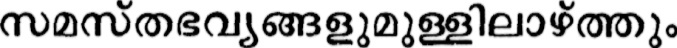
സമസതഭവ്യങ്ങളുമുള്ളിലാഴ്ത്തും
